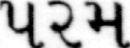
પરમ
